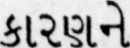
કારણને
